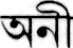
অনী
